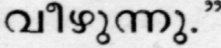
വീഴുന്നു.”
